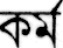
কর্ম
